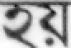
হয়
